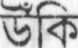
উঁকি
